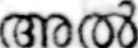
അല്‍
